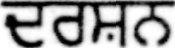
ਦਰਸ਼ਨ
